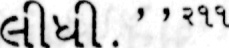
લીધી."૨૧૧
